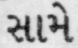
સામે
